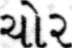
ચોર
